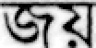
জয়
